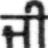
ਜੀ
